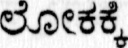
ಲೋಕಕ್ಕೆ
